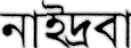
নাইদ্রবা
